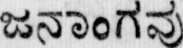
ಜನಾಂಗವು
